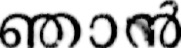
ഞാന്‍
